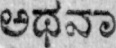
ಅಥವಾ
